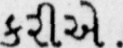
કરીએ.
